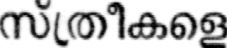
സ്ത്രീകളെ
